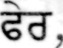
ਫੇਰ,
